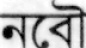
নবৌ
